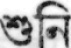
শুনি
